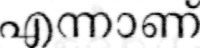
എന്നാണ്
